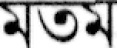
মতম
